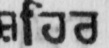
ਸ਼ਹਿਰ
